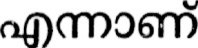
എന്നാണ്
